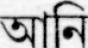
আনি
